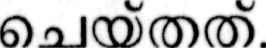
ചെയ്തത്.
